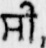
ਸੀ,
